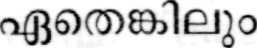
ഏതെങ്കിലും
